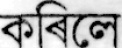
কৰিলে
